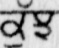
ਕੁੱਝ
